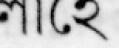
লাহে
